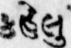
કહેલું
